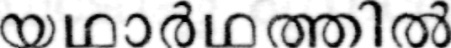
യഥാര്‍ഥത്തില്‍
